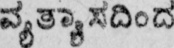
ವ್ಯತ್ಯಾಸದಿಂದ
